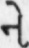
ને
